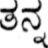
ತನ್ನ
